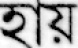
হায়
